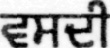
ਵਸਦੀ
